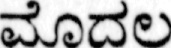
ಮೊದಲ
